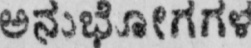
ಅನುಭೋಗಗಳ
